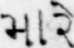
મારે
